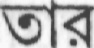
তার
